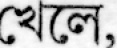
খেলে,
